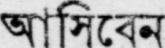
আসিবেন
